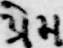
પ્રેમ
